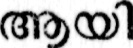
ആയി
